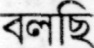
বলছি
